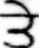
ਤੇ
